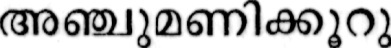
അഞ്ചുമണിക്കൂറു
